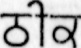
ਠੀਕ
